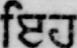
ਇਹ
